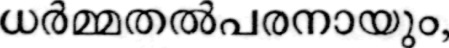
ധര്‍മ്മതല്‍പരനായും,
